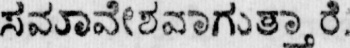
ಸಮಾವೇಶವಾಗುತ್ತಾರೆ.
